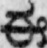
ಈ
